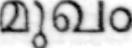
മുഖം
